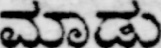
ಮಾಡು
